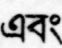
এবং
